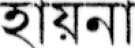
হায়না
